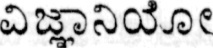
ವಿಜ್ಞಾನಿಯೋ
